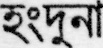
হংদুনা
